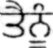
ਤੈਨੂੰ
